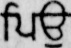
ਪਿਉ
